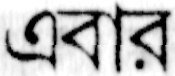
এবার
